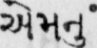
એમનું
